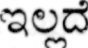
ಇಲ್ಲದೆ
